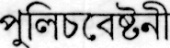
পুলিচবেষ্টনী
